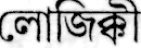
লোজিক্কী
